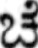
ಚೆ
